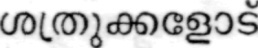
ശത്രുക്കളോട്
